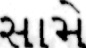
સામે
